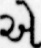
એ
